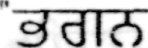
''ਭਗਨ
